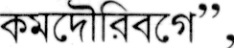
কমদৌরিবগে”,
